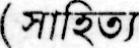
(সাহিত্য
